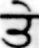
ਤੇ
